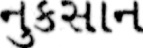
નુકસાન
